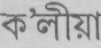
ক'লীয়া
